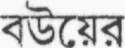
বউয়ের
